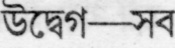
উদ্বেগ–সব
